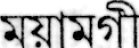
ময়ামগী
